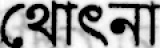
থোৎনা
